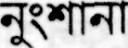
নুংশানা
